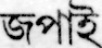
জপাই
